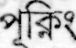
পূক্নিং
